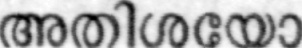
അതിശയോ
